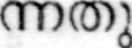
ന്നതു
